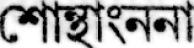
শোন্থাংননা
